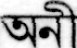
অনী
